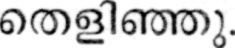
തെളിഞ്ഞു.
